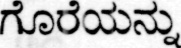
ಗೊರೆಯನ್ನು
